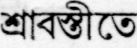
শ্রাবস্তীতে
